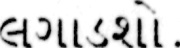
લગાડશો.
